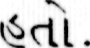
હતો.
